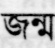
জন্ম
